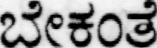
ಬೇಕಂತೆ
